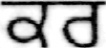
ਕਰ
